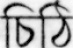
চিঠি
